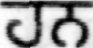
ਹਨ
